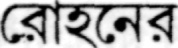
রোহনের
